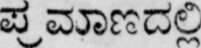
ಪ್ರಮಾಣದಲ್ಲಿ
